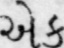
એક
